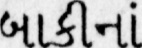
બાકીનાં
